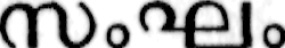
സംഘം
